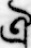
ঐ
